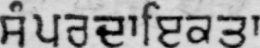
ਸੰਪਰਦਾਇਕਤਾ
